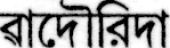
ৱাদৌরিদা
